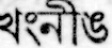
খংনীঙ
